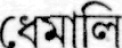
ধেমালি
